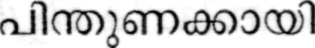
പിന്തുണക്കായി
